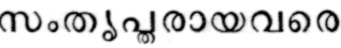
സംതൃപ്തരായവരെ
